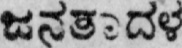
ಜನತಾದಳ
